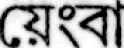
য়েংবা
